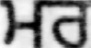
ਮਰ
